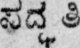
ಪದ್ಧತಿ
